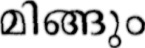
മിങ്ങും
